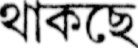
থাকছে
